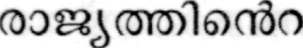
രാജ്യത്തിന്റെ
